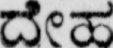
ದೇಹ
